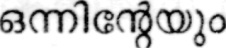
ഒന്നിന്റേയും
